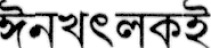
ঈনখৎলকই
